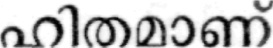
ഹിതമാണ്
